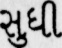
સુધી
